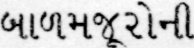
બાળમજૂરોની
